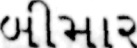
બીમાર
